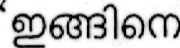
'ഇങ്ങിനെ
